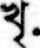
খৃ.
